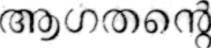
ആഗതന്റെ
